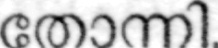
തോന്നി.
